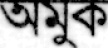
অমুক
